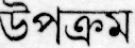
উপক্রম
